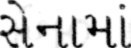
સેનામાં
